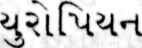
યુરોપિયન
